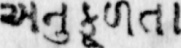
અનુકૂળતા
